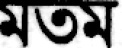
মতম
